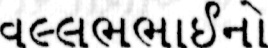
વલ્લભભાઈનો
